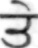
ਤੇ
